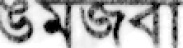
ঙমজবা
